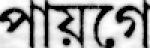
পায়গে
